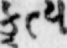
કૃત્ય
